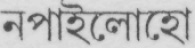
নপাইলোহো
